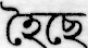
হৈছে
